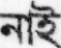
নাই
